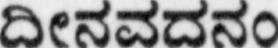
ದೀನವದನಂ
